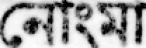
নোংমা
